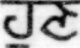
ਹੁਣ
